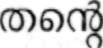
തന്റെ
